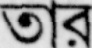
তার
